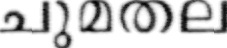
ചുമതല
